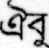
ঐবু
